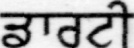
ਡਾਰਟੀ
